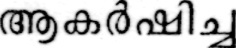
ആകര്‍ഷിച്ച
